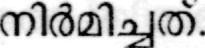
നിര്‍മിച്ചത്.
